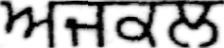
ਅਜਕਲ
